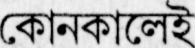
কোনকালেই
